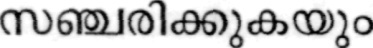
സഞ്ചരിക്കുകയും
